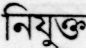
নিযুক্ত
